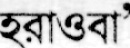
হরাওবা’
